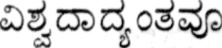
ವಿಶ್ವದಾದ್ಯಂತವೂ
